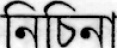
নিচিনা
